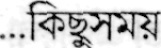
...কিছুসময়
